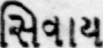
સિવાય
